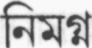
নিমগ্ন
